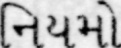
નિયમો
